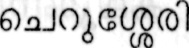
ചെറുശ്ശേരി
